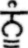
ਨੂੰ
